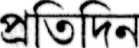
প্রতিদিন
